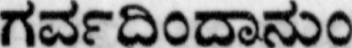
ಗರ್ವದಿಂದಾನುಂ
